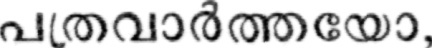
പത്രവാര്‍ത്തയോ,
